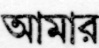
আমার
